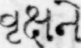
વક્ષને
